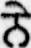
ਨੇ
